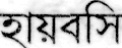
হায়বসি
